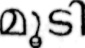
മൂടി
